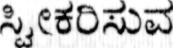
ಸ್ವೀಕರಿಸುವ
